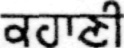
ਕਹਾਣੀ
